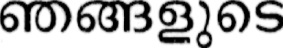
ഞങ്ങളുടെ
